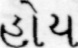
હોય
